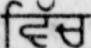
ਵਿੱਚ
